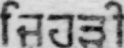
ਜਿਹੜੀ
